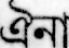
ঐনা
